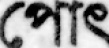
পোৎ
